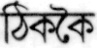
ঠিককৈ
